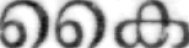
കൈ
